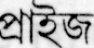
প্রাইজ
